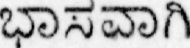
ಭಾಸವಾಗಿ
